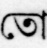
তো
